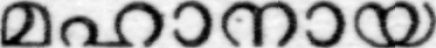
മഹാനായ
